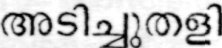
അടിച്ചുതളി
